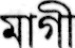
মাগী
